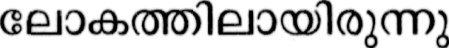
ലോകത്തിലായിരുന്നു
